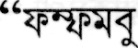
“ফম্ফমবু
